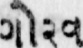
ગૌરવ
